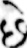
છે
